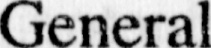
General
